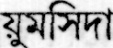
য়ুমসিদা
